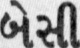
બેસી
